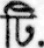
টি.
